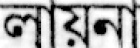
লায়না
